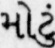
મોટું
